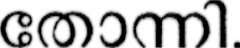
തോന്നി.
